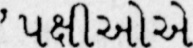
પક્ષીઓએ
